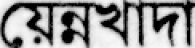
য়েন্নখাদা
